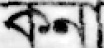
কনা
